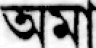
অমা
